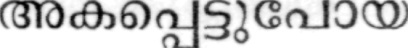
അകപ്പെട്ടുപോയ
